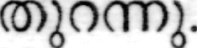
തുറന്നു.
